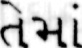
તેમાં
